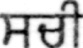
ਸਚੀ
